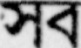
সব
